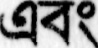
এবং
